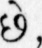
છે,
